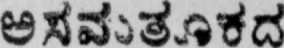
ಅಸಮತೂಕದ
